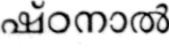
ഷ്ഠനാല്‍
